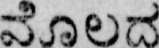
ಮೊಲದ
